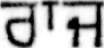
ਰਾਜ
